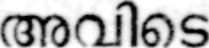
അവിടെ
